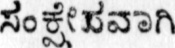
ಸಂಕ್ಷೇಪವಾಗಿ
